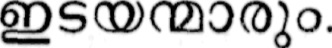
ഇടയന്മാരും.
